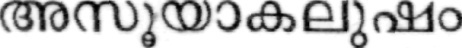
അസൂയാകലുഷം
